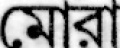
মোরা
